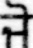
ਜੋ
